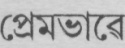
প্ৰেমভাৱে
